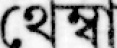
থেম্বা
